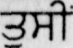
ਤੁਸੀਂ
